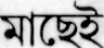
মাছেই
